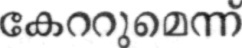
കേററുമെന്ന്
